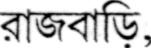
রাজবাড়ি,
